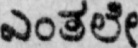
ಎಂತಲೇ
